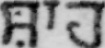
ਸ਼ਾਹ
